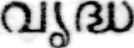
വൃദ്ധ
